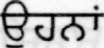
ਉਹਨਾਂ
